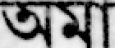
অমা
